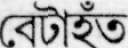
বেটাহঁত
